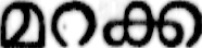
മറക്ക
